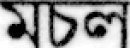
মচল
